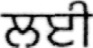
ਲਈ
